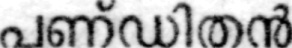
പണ്ഡിതന്‍
